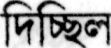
দিচ্ছিল
